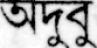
অদুবু
